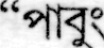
“পাবুং
